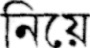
নিয়ে
